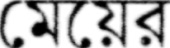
মেয়ের
